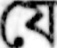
যে
